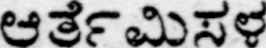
ಆರ್ತೆಮಿಸಳ
